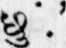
છુ.'
